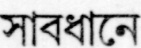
সাবধানে
